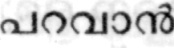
പറവാന്‍
